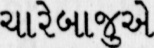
ચારેબાજુએ
